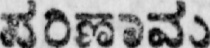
ಪರಿಣಾಮ
